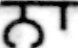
ਨਾ
